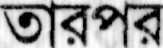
তারপর
